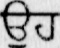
ਉਹ
